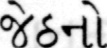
જેઠનો
